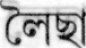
লৈছা
